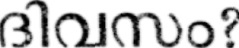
ദിവസം?
